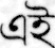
এই
